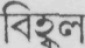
বিহ্বল
